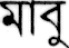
মাবু
